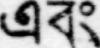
এবং
